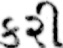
કરી
